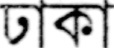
ঢাকা
